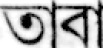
তাবা
